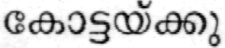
കോട്ടയ്ക്കു
